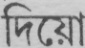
দিয়ো
